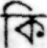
কি
